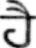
ਹੈ
